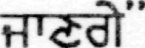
ਜਾਣਗੇ''
